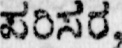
ಪರಿಸರ,
